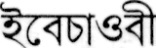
ইবেচাওবী
